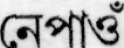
নেপাওঁ
